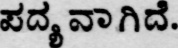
ಪದ್ಯವಾಗಿದೆ.
